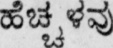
ಹೆಚ್ಚಳವು
